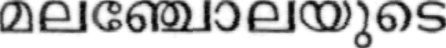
മലഞ്ചോലയുടെ
